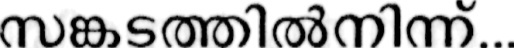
സങ്കടത്തില്‍നിന്ന്...
